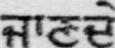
ਜਾਣਦੇ
